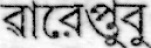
ৱারেপ্তুবু
